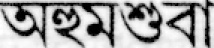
অহুমশুবা
